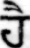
ਹੈ
